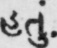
હતું.
